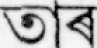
তাৰ
